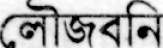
লৌজবনি
